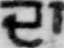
ਦਾ
